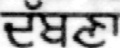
ਦੱਬਣਾ
